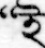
“ই
